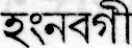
হংনবগী
